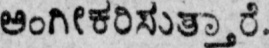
ಅಂಗೀಕರಿಸುತ್ತಾರೆ.
